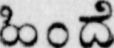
ಹಿಂದೆ
